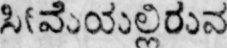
ಸೀಮೆಯಲ್ಲಿರುವ
